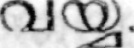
വയ്യ.
